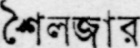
শৈলজার
